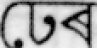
ঢেৰ
